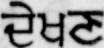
ਦੇਖਣ
